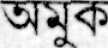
অমুক
